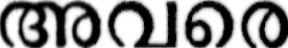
അവരെ
